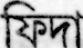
ফিদা
